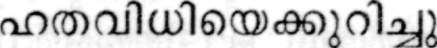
ഹതവിധിയെക്കുറിച്ചു
